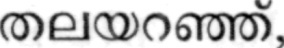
തലയറഞ്ഞ്,
